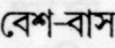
বেশ-বাস
